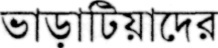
ভাড়াটিয়াদের
